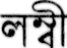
লম্বী
